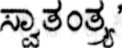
ಸ್ವಾತಂತ್ರ್ಯ'
